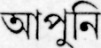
আপুনি
